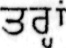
ਤਰ੍ਹਾਂ
